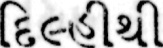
દિલ્હીથી
